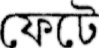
ফেটে
